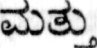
ಮತ್ತು
